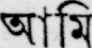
আমি
